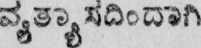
ವ್ಯತ್ಯಾಸದಿಂದಾಗಿ
